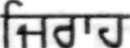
ਜਿਰਾਹ
